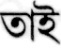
তাই
